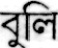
বুলি
